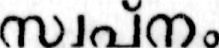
സ്വപ്നം
